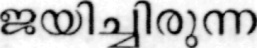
ജയിച്ചിരുന്ന
